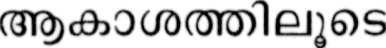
ആകാശത്തിലൂടെ
